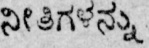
ನೀತಿಗಳನ್ನು
